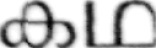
കഥ
